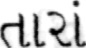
તારાં
